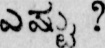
ಎಷ್ಟು?
